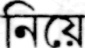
নিয়ে
